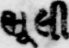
ભૂલી
